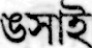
ঙসাই
